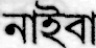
নাইবা
